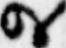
જ
